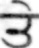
ਤੇ
